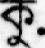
কু.
